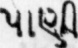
પાણી
